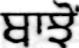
ਬਾਝੋਂ
